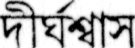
দীর্ঘশ্বাস
